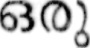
ഒരു
